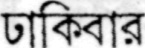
ঢাকিবার
